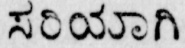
ಸರಿಯಾಗಿ
